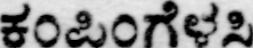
ಕಂಪಿಂಗೆಳಸಿ
